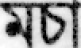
মচা
